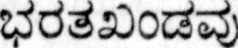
ಭರತಖಂಡವು
